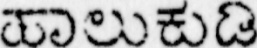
ಹಾಲುಕುಡಿ
